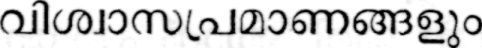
വിശ്വാസപ്രമാണങ്ങളും
